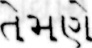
તેમણે
